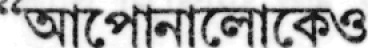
"আপোনালোকেও
